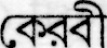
কেরবী
